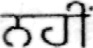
ਨਹੀਂ
